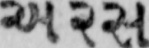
અરસ
